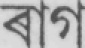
ৰাগ
